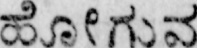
ಹೋಗುವ
